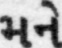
મને
